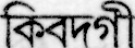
কিবদগী
